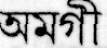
অমগী
